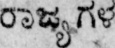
ರಾಜ್ಯಗಳ
